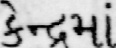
કેન્દ્રમાં
